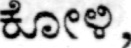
ಕೋಳಿ,
